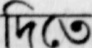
দিতে
